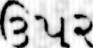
ઉપર
